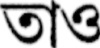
তাও
